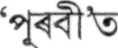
'পূৰবী'ত
